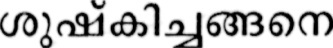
ശുഷ്കിച്ചങ്ങനെ
